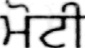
ਮੋਟੀ
